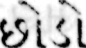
છોડો
